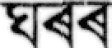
ঘৰৰ
